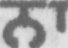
ਨਾ
